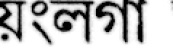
য়েংলগা
